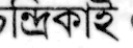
চন্দ্ৰিকাই
